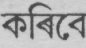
কৰিবে
